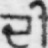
ਦੀ
